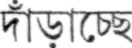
দাঁড়াচ্ছে
